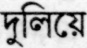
দুলিয়ে
